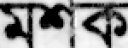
মশক
